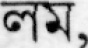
লম,
